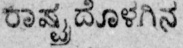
ರಾಷ್ಟ್ರದೊಳಗಿನ
